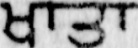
ਖਾਤਾ
